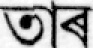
তাৰ
